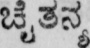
ಚೈತನ್ಯ
